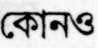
কোনও
